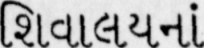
શિવાલયનાં
